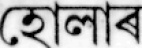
হোলাৰ
